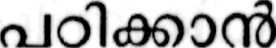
പഠിക്കാന്‍
